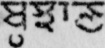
ਬ੍ਹਝਾਣ
